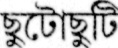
ছুটোছুটি
